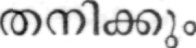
തനിക്കും
